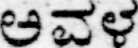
ಅವಳ
